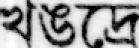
খঙদ্রে
